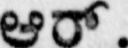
ಆರ್.
